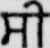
ਸੀ
